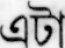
এটা
